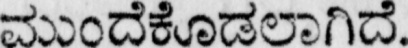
ಮುಂದೆಕೊಡಲಾಗಿದೆ.
